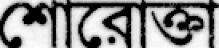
শোরোক্তা
